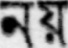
নয়
